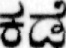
ಕಡೆ
